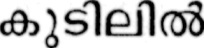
കുടിലില്‍
